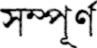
সম্পূর্ণ
